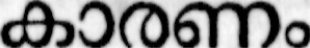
കാരണം
